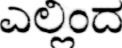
ಎಲ್ಲಿಂದ
